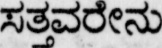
ಸತ್ತವರೇನು
